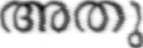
അതു
